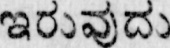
ಇರುವುದು
